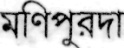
মণিপুরদা
